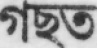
গছত
